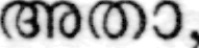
അതാ,
